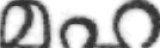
മഹ
